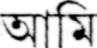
আমি
